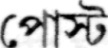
পোস্ট
